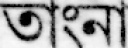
তাংনা
